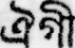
ঐগী
